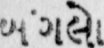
બંગલો
